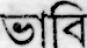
ভাবি
